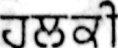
ਹਲਕੀ
